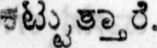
ಕಟ್ಟುತ್ತಾರೆ.
